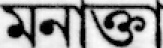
মনাক্তা
